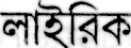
লাইরিক
